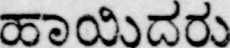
ಹಾಯಿದರು
